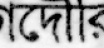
অমুক
